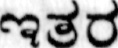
ಇತರ
